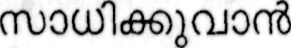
സാധിക്കുവാന്‍
